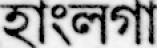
হাংলগা
